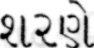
શરણે
